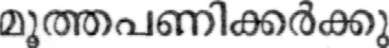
മൂത്തപണിക്കര്‍ക്കു
